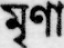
মৃণা
